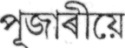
পূজাৰীয়ে
